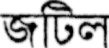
জটিল
